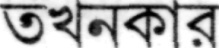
তখনকার
